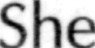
She
